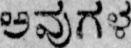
ಅವುಗಳ
